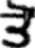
ਤੋਂ
